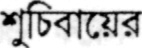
শুচিবায়ের
